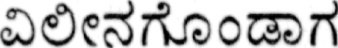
ವಿಲೀನಗೊಂಡಾಗ
